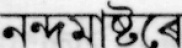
নন্দমাষ্টৰে
